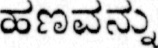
ಹಣವನ್ನು
